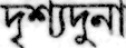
দৃশ্যদুনা
